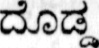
ದೊಡ್ಡ
